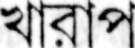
খারাপ
